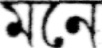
মনে
